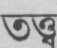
তত্ত্ব
